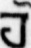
ਹੋ
